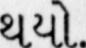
થયો.
